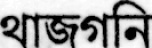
থাজগনি
